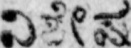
ವಿಶೇಷ
